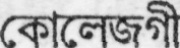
কোলেজগী
